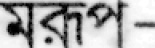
মরূপ-
